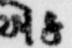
એક
